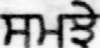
ਸਮਝੇ
